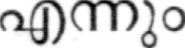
എന്നും
